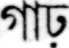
গাঢ়
